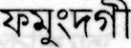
ফমুংদগী
